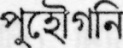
পুহৌগনি
